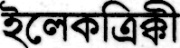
ইলেকত্রিক্কী
